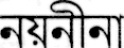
নয়নীনা
